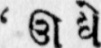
'ઊંધે
